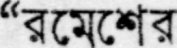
‘‘রমেশের
